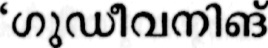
‘ഗുഡീവനിങ്
